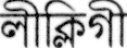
লীক্লিগী
